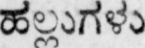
ಹಲ್ಲುಗಳು
